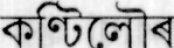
কণ্টিলৌৰ
